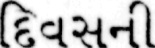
દિવસની
